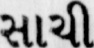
સાચી
